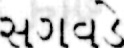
સગવડે
